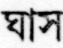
ঘাস
